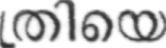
ത്രിയെ
